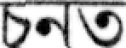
চনত
